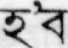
হ'ব
